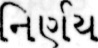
નિર્ણય
